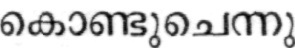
കൊണ്ടുചെന്നു
